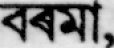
বৰমা,
